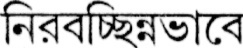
নিরবচ্ছিন্নভাবে
